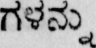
ಗಳನ್ನು
